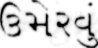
ઉમેરવું
